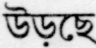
উড়ছে
